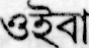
ওইবা
